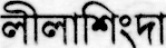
লীলাশিংদা
